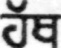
ਹੱਥ
